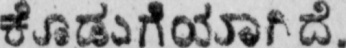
ಕೊಡುಗೆಯಾಗಿದೆ.
